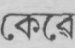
কেৱে
